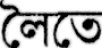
লৈতে
